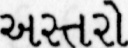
અસ્તરો
